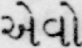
એવો
